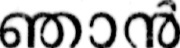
ഞാന്‍
